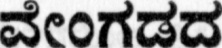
ವೇಂಗಡದ
